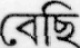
বেছি
